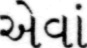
એવાં
